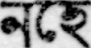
নহে
